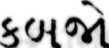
કબજો
